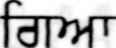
ਗਿਆ
